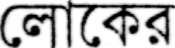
লোকের
